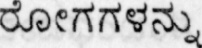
ರೋಗಗಳನ್ನು
